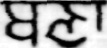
ਬਣਾ
